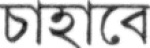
চাহাবে
